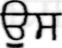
ਉਸ
